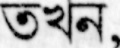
তখন,
